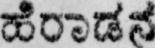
ಹೆರಾಡನ
